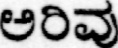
ಅರಿವು
